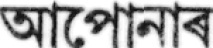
আপোনাৰ
